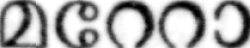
മറേറാ
